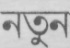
নতুন
